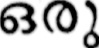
ഒരു
